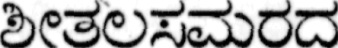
ಶೀತಲಸಮರದ
